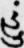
હું
